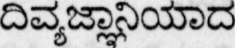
ದಿವ್ಯಜ್ಞಾನಿಯಾದ
